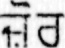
ਜ਼ੋਰ
